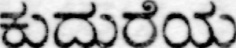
ಕುದುರೆಯ
